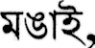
মঙাই,
